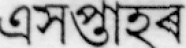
এসপ্তাহৰ
